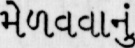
મેળવવાનું
